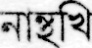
নান্থখি
